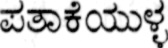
ಪತಾಕೆಯುಳ್ಳ
